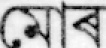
মোৰ
